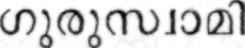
ഗുരുസ്വാമി
